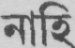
নাহি
